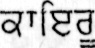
ਕਾਇਰੂ
